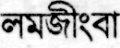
লমজীংবা
